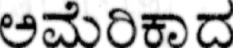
ಅಮೆರಿಕಾದ
